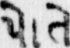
,પોતે
